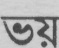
ভয়
